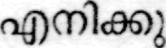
എനിക്കു
